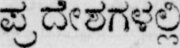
ಪ್ರದೇಶಗಳಲ್ಲಿ
